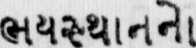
ભયસ્થાનનો
